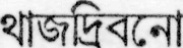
থাজদ্রিবনো
